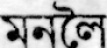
মনলৈ
